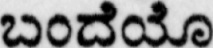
ಬಂದೆಯೊ
